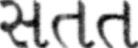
સતત
